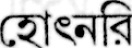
হোৎনরি
